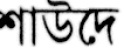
শাউদে
